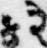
કરે
